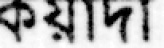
কয়াদা
